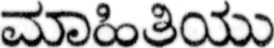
ಮಾಹಿತಿಯು
